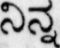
ನಿನ್ನ
